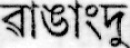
ৱাঙাংদু
